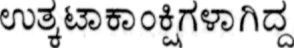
ಉತ್ಕಟಾಕಾಂಕ್ಷಿಗಳಾಗಿದ್ದ
